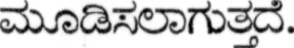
ಮೂಡಿಸಲಾಗುತ್ತದೆ.
